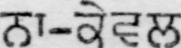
ਨਾ-ਕੇਵਲ
